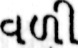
વળી
